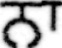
ਨਾ
